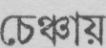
চেঞ্চায়
